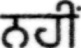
ਨਹੀਂ
